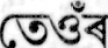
তেওঁৰ
